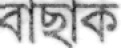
বাছাক
